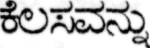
ಕೆಲಸವನ್ನು
